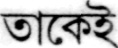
তাকেই
